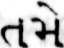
તમે
